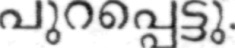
പുറപ്പെട്ടു.
